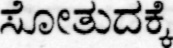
ಸೋತುದಕ್ಕೆ
